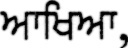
ਆਖਿਆ,
